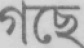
গছে
